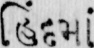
હિંદમાં
